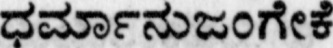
ಧರ್ಮಾನುಜಂಗೇಕೆ
